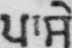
ਪਾਸੇ
